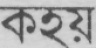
কহয়
